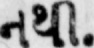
નથી.
